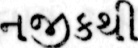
નજીકથી
